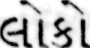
લોકો
